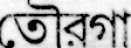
তৌরগা
